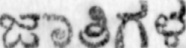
ಜಾತಿಗಳ
